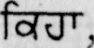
ਕਿਹਾ,
